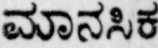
ಮಾನಸಿಕ
